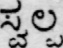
ಸ್ವಲ್ಪ
